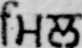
ਮਿਲ
